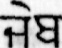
ਜੇਬ
